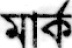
মার্ক
